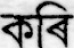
কৰি
